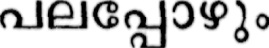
പലപ്പോഴും
